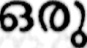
ഒരു
